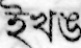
ইখঙ
